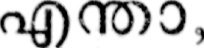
എന്താ,
